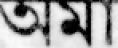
অমা
